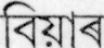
বিয়াৰ
